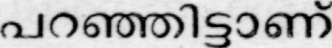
പറഞ്ഞിട്ടാണ്
